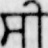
ਸੀ
